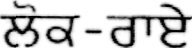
ਲੋਕ-ਰਾਏ
